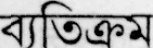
ব্যতিক্রম
